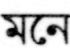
মনে
